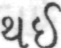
થઈ
